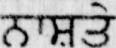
ਨਾਸ਼ਤੇ
